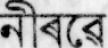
নীৰৱে
